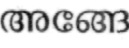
അങ്ങേ
